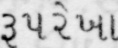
રૂપરેખા
